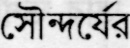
সৌন্দর্যের
